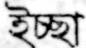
ইচ্ছা
